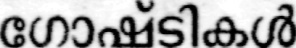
ഗോഷ്ടികള്‍
